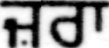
ਜ਼ਰਾ
